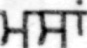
ਮਸਾਂ
